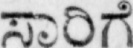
ಸಾರಿಗೆ
